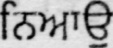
ਨਿਆਉ
